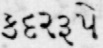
કદરરૂપે
